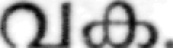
വക.
